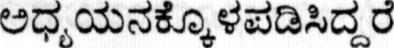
ಅಧ್ಯಯನಕ್ಕೊಳಪಡಿಸಿದ್ದರೆ
